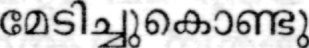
മേടിച്ചുകൊണ്ടു
